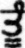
ਤੂੰ
